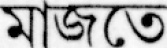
মাজতে
